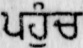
ਪਹੁੰਚ
